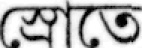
স্ৰোতে
